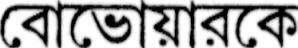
বোভোয়ারকে
